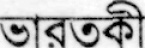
ভারতকী
